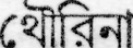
থৌরিনা
